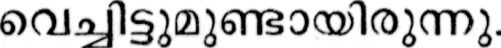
വെച്ചിട്ടുമുണ്ടായിരുന്നു.
